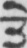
ਤੇ
